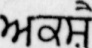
ਅਕਸ਼ੈ
